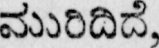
ಮುರಿದಿದೆ,
